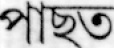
পাছত
